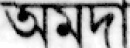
অমদা
